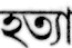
হত্যা
